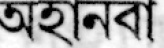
অহানবা
